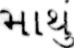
માથું
